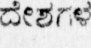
ದೇಶಗಳ
